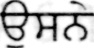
ਉਸਨੇ
